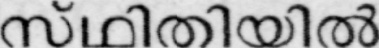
സ്ഥിതിയില്‍
